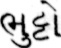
ભુટ્ટો
